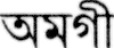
অমগী
